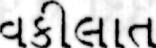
વકીલાત
